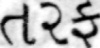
તરફ
